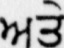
ਅਤੇ
